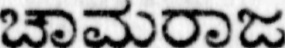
ಚಾಮರಾಜ
